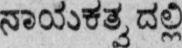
ನಾಯಕತ್ವದಲ್ಲಿ
